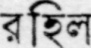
রহিল
